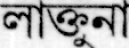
লাক্তুনা
